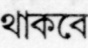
থাকবে
